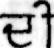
ਦੀ
